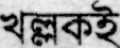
খল্লকই
